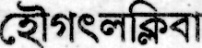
হৌগৎলক্লিবা
